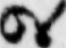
જ
